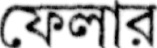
ফেলার
